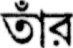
তাঁর
